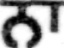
ਨਾ
